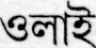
ওলাই
